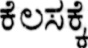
ಕೆಲಸಕ್ಕೆ
